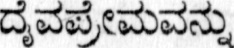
ದೈವಪ್ರೇಮವನ್ನು
